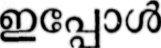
ഇപ്പോള്‍
